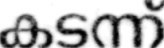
കടന്ന്
